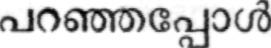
പറഞ്ഞപ്പോള്‍
